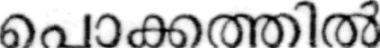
പൊക്കത്തില്‍
